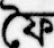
ফৈ
